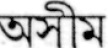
অসীম
